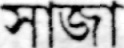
সাজা
